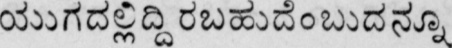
ಯುಗದಲ್ಲಿದ್ದಿರಬಹುದೆಂಬುದನ್ನೂ
